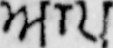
ਆਪ
